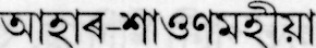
আহাৰ-শাওণমহীয়া
